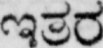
ಇತರ
